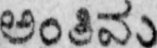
ಅಂತಿಮ
